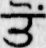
ਤੋਂ
